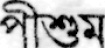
পীশুম
